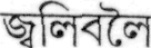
জ্বলিবলৈ
